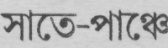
সাতে-পাঞ্চে
